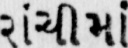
રાંચીમાં
